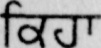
ਕਿਹਾ
